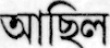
আছিল
